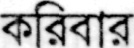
করিবার
